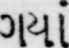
ગયાં
